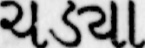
ચડ્યા
